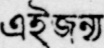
এইজন্য
